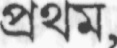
প্রথম,
